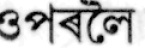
ওপৰলৈ
